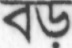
বড়
